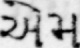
એમ
